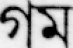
গম
